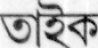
তাইক
